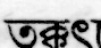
থারিবা
